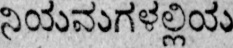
ನಿಯಮಗಳಲ್ಲಿಯ
